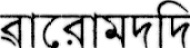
ৱারোমদদি
